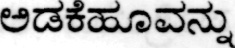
ಅಡಕೆಹೂವನ್ನು
